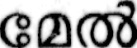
മേല്‍
